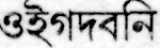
ওইগদবনি
